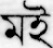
মই
